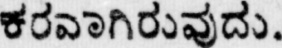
ಕರವಾಗಿರುವುದು.
